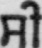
ਸੀ
